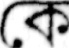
কে
